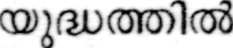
യുദ്ധത്തില്‍
